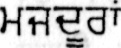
ਮਜਦੂਰਾਂ
